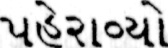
પહેરાવ્યો
